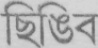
ছিঙিব
